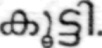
കൂട്ടി.
